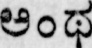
ಅಂಥ
